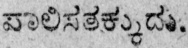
ಪಾಲಿಸತಕ್ಕುದು.
